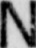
N
